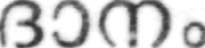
ദാനം
